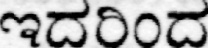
ಇದರಿಂದ
